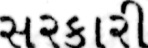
સરકારી
